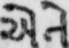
એને
